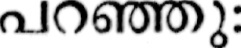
പറഞ്ഞു:
